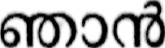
ഞാന്‍
